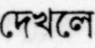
দেখলে
